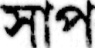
সাপ
